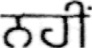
ਨਹੀਂ
